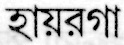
হায়রগা
